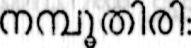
നമ്പൂതിരി:
